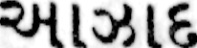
આઝાદ
